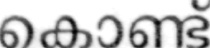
കൊണ്ട്
